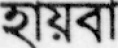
হায়বা
